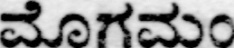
ಮೊಗಮಂ
